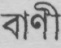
বাণী
